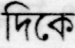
দিকে
